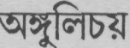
অঙ্গুলিচয়
